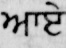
ਆਏ
